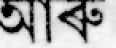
আৰু
